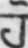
ਹੋ
